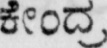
ಕೇಂದ್ರ
